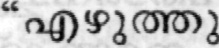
"എഴുത്തു
